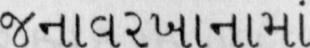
જનાવરખાનામાં
